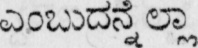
ಎಂಬುದನ್ನೆಲ್ಲಾ
